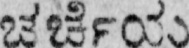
ಚರ್ಚೆಯ
